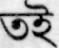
তই
